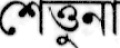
শেত্তুনা
